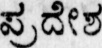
ಪ್ರದೇಶ
